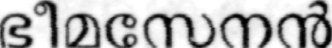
ഭീമസേനന്‍
